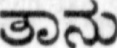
ತಾನು
